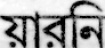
য়ারনি
